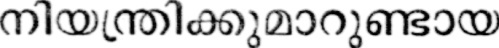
നിയന്ത്രിക്കുമാറുണ്ടായ
